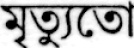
মৃত্যুতো
